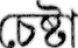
চেষ্টা
